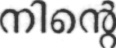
നിന്റെ
